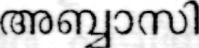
അബ്ബാസി
